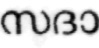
സദാ
